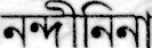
নন্দীনিনা
